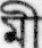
মী
